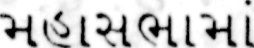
મહાસભામાં
